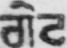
ਗੇਟ
